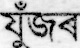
যুঁজৰ
